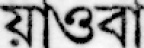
য়াওবা
